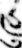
હું
